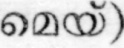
മെയ്)
